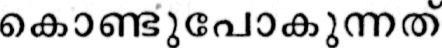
കൊണ്ടുപോകുന്നത്
